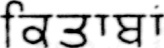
ਕਿਤਾਬਾਂ
